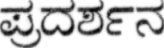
ಪ್ರದರ್ಶನ
